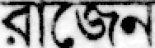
রাজেন
